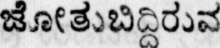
ಜೋತುಬಿದ್ದಿರುವ
